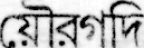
য়ৌরগদি
